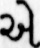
એ
